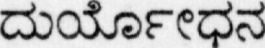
ದುರ್ಯೋಧನ
